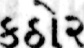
કઠોર
